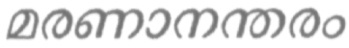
മരണാനന്തരം
